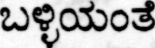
ಬಳ್ಳಿಯಂತೆ
